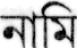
নামি
